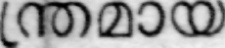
ന്ത്രമായ
